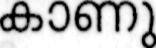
കാണു
